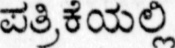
ಪತ್ರಿಕೆಯಲ್ಲಿ
